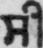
ਸੀ
